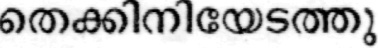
തെക്കിനിയേടത്തു
